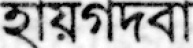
হায়গদবা
